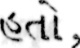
હતો,
